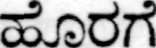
ಹೊರಗೆ
